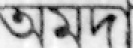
অমদা
